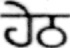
ਹੇਠ
